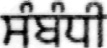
ਸੰਬੰਧੀ
